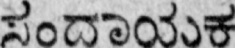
ಸಂದಾಯಕ
